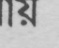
যায়
